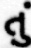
તું
